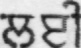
ਲਈ
